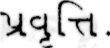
પ્રવૃત્તિ.
